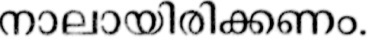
നാലായിരിക്കണം.
